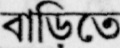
বাড়িতে
